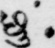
છું.
